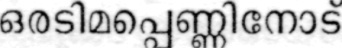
ഒരടിമപ്പെണ്ണിനോട്
